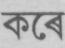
কৰে
